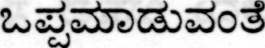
ಒಪ್ಪಮಾಡುವಂತೆ
